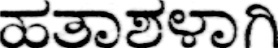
ಹತಾಶಳಾಗಿ
